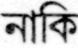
নাকি
